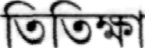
তিতিক্ষা
